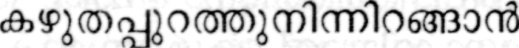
കഴുതപ്പുറത്തുനിന്നിറങ്ങാന്‍
